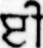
ਈ
